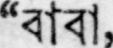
‘‘বাবা,
